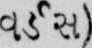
વર્ડસ)
